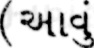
(આવું
